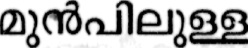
മുന്‍പിലുള്ള
